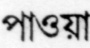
পাওয়া
